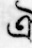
ঐ
